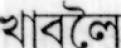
খাবলৈ
